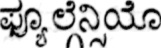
ಪ್ಯೂಲ್ಗೆನ್ಸಿಯೊ
